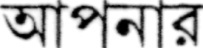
আপনার
